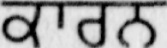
ਕਾਰਨ
